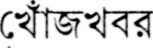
খোঁজখবর
